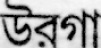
উরগা
